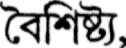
বৈশিষ্ট্য,
